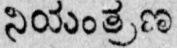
ನಿಯಂತ್ರಣ
